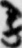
કે
